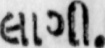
લાગી.
